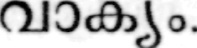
വാക്യം.
